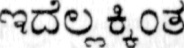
ಇದೆಲ್ಲಕ್ಕಿಂತ
